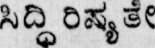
ಸಿದ್ಧಿರಿಷ್ಯತೇ
